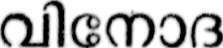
വിനോദ
